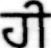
ਹੀ
